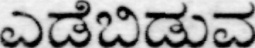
ಎಡೆಬಿಡುವ
